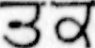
ਤਕ
